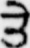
ਤੇ
